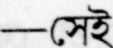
–সেই
